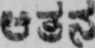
ಆತನ
